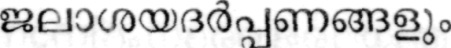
ജലാശയദര്‍പ്പണങ്ങളും
